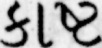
કાષ્ટ
